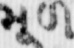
મૂળ
